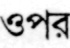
ওপর
